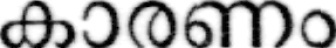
കാരണം
